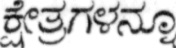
ಕ್ಷೇತ್ರಗಳನ್ನೂ
